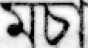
মচা
